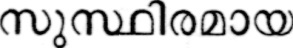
സുസ്ഥിരമായ
